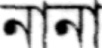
নানা
